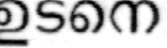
ഉടനെ
